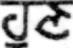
ਹੁਣ
